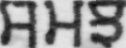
ਸਮਝ
